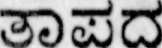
ತಾಪದ
